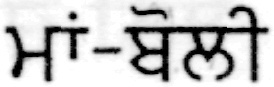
ਮਾਂ-ਬੋਲੀ
